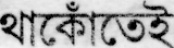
থাকোঁতেই
